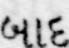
બાદ
